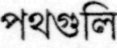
পথগুলি
